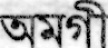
অমগী
